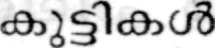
കുട്ടികള്‍
